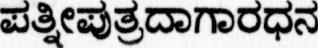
ಪತ್ನೀಪುತ್ರದಾಗಾರಧನ
